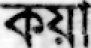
কয়া
